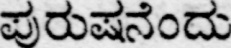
ಪುರುಷನೆಂದು
